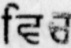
ਵਿਚ
